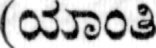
(ಯಾಂತಿ
